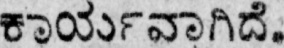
ಕಾರ್ಯವಾಗಿದೆ.
